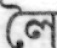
লৈ
